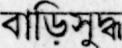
বাড়িসুদ্ধ
